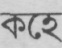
কহে
